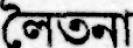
লৈতনা
